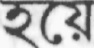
হয়ে
